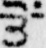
ਤੋਂ
